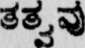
ತತ್ವವು
